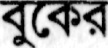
বুকের
